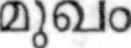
മുഖം
